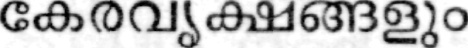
കേരവൃക്ഷങ്ങളും
